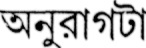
অনুরাগটা
